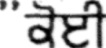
''ਕੋਈ
